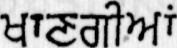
ਖਾਣਗੀਆਂ
